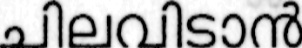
ചിലവിടാന്‍
